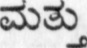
ಮತ್ತು
